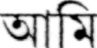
আমি
